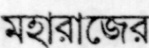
মহারাজের
